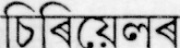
চিৰিয়েলৰ
